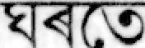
ঘৰতে
